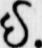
ઈ.
